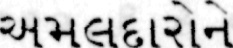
અમલદારોને
